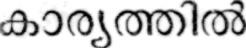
കാര്യത്തില്‍
